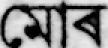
মোৰ
